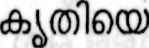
കൃതിയെ
